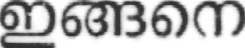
ഇങ്ങനെ
